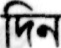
দিন
